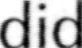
did
